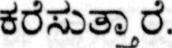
ಕರೆಸುತ್ತಾರೆ.
